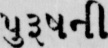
પુરૂષની
